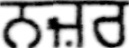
ਨਜ਼ਰ
